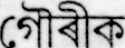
গৌৰীক
